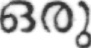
ഒരു
